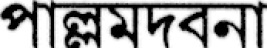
পাল্লমদবনা
